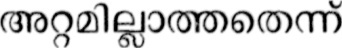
അറ്റമില്ലാത്തതെന്ന്
